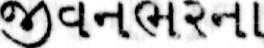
જીવનભરના
